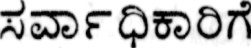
ಸರ್ವಾಧಿಕಾರಿಗೆ
